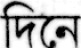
দিনে
